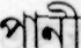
পানী
